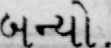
બન્યો.
